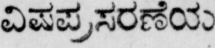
ವಿಷಪ್ರಸರಣೆಯ
